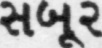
સબૂર
